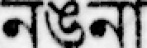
নঙনা
